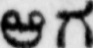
ಆಗ
